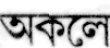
অকলে
